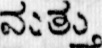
ಮತ್ತು
